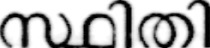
സ്ഥിതി
